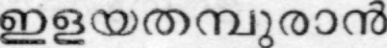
ഇളയതമ്പുരാന്‍
